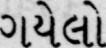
ગયેલો
